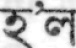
হ'ল
